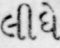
લીધે
